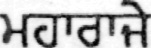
ਮਹਾਰਾਜੇ
